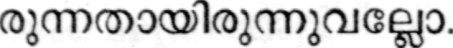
രുന്നതായിരുന്നുവല്ലോ.
